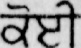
ਕੋਈ
